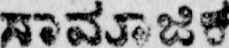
ಸಾಮಾಜಿಕ
